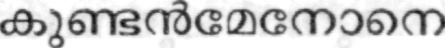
കുണ്ടന്‍മേനോനെ
